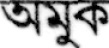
অমুক
